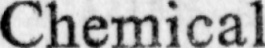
Chemical
